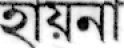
হায়না
